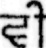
ਵੀ
